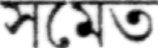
সমেত
